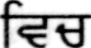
ਵਿਚ
